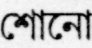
শোনো
